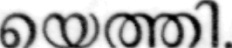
യെത്തി.
